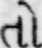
તો
